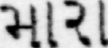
મારા
